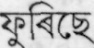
ফুৰিছে
